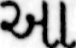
આ
